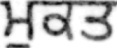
ਮੁਕਤ
